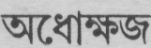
অধোক্ষজ
